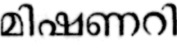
മിഷണറി
